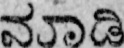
ಮಾಡಿ
